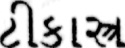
ટીકાસ્ત્ર
